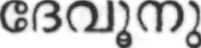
ദേവൂനു
